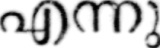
എന്നു
